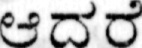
ಆದರೆ
